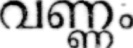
വണ്ണം
